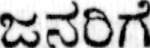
ಜನರಿಗೆ
